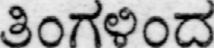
ತಿಂಗಳಿಂದ
